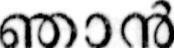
ഞാന്‍
